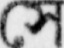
সে
